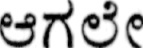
ಆಗಲೇ
